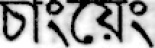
চাংয়েং
